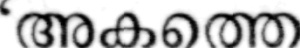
'അകത്തെ
